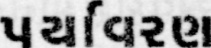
પર્યાવરણ
